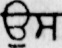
ਉਸ
